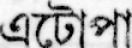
এটোপা
